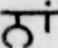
ਨਾਂ
